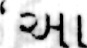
આ
